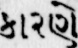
કારણે
